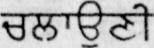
ਚਲਾਉਣੀ
